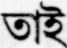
তাই
